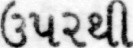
ઉપરથી
